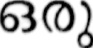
ഒരു
